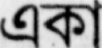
একা
